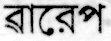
ৱারেপ
